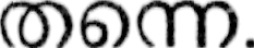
തന്നെ.
